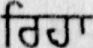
ਰਿਹਾ
